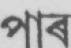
পাৰ
